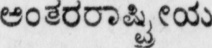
ಅಂತರರಾಷ್ಟ್ರೀಯ
